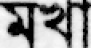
মখা
